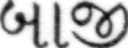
બાજી
